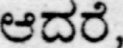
ಆದರೆ,
